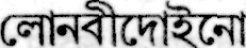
লোনবীদোইনো
